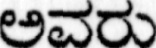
ಅವರು
